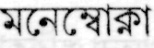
মনেম্বোক্না
